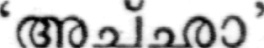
‘അച്ഛാ’
